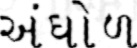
અંઘોળ
